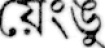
য়েংঙু
